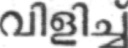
വിളിച്ച്
